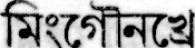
মিংগৌনখ্রে
